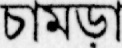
চামড়া
